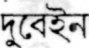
দুবেইন
